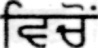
ਵਿਚੋਂ
